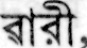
ৱারী,
